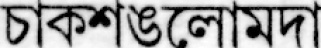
চাকশঙলোমদা
